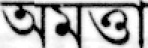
অমত্তা
